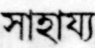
সাহায্য
